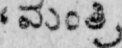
‘ಮಂತ್ರಿ
